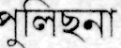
পুলিছনা
